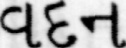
વદન
